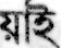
য়াই
